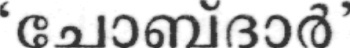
'ചോബ്ദാര്‍'
